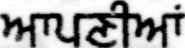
ਆਪਣੀਆਂ
